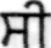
ਸੀ
